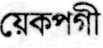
য়েকপগী
